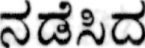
ನಡೆಸಿದ
